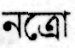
নত্রো
